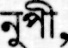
নুপী,
